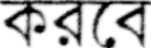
করবে
